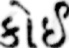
કોઈ
